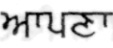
ਆਪਣਾ
